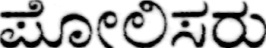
ಪೋಲಿಸರು
